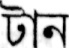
টান
